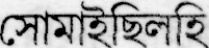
সোমাইছিলহি
